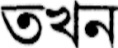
তখন
